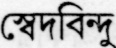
স্বেদবিন্দু
